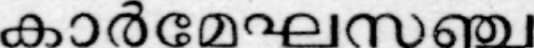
കാര്‍മേഘസഞ്ച
